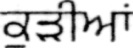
ਕੁੜੀਆਂ
